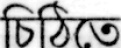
চিঠিতে
